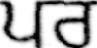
ਪਰ
